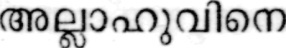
അല്ലാഹുവിനെ
